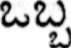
ಒಬ್ಬ
